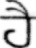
ਹੈ
